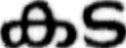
കട
